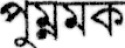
পুম্নমক
